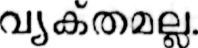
വ്യക്തമല്ല.
